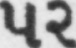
પર
